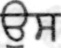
ਉਸ
